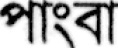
পাংবা
